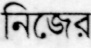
নিজের
